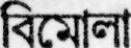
বিমোলা
